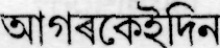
আগৰকেইদিন
